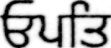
ਓਪਤਿ
